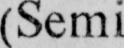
(Semi
